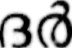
ദര്‍
